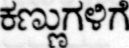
ಕಣ್ಣುಗಳಿಗೆ
